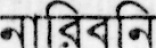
নারিবনি
